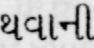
થવાની
